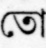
তো
